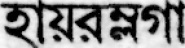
হায়রম্লগা
